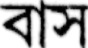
বাস
